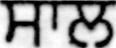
ਸਾਲ
